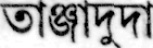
তাঞ্জাদুদা
